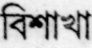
বিশাখা
